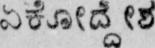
ಏಕೋದ್ದೇಶ
